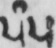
ਪੰਪ
